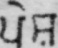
ਪੇਸ਼
